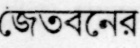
জেতবনের
